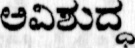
ಅವಿಶುದ್ಧ
